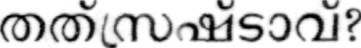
തത്സ്രഷ്ടാവ്?
